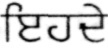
ਇਹਦੇ
